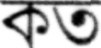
কত
